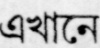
এখানে
